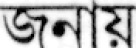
জনায়
